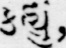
કહ્યું,
